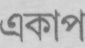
একাপ
